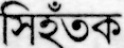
সিহঁতক
